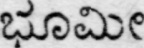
ಭೂಮಿ
